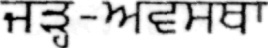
ਜੜ੍ਹ-ਅਵਸਥਾ
